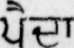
ਪੈਦਾ
